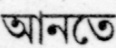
আনতে
